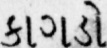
કાગડો
